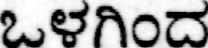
ಒಳಗಿಂದ
